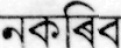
নকৰিব
